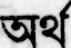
অর্থ
